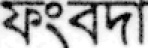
ফংবদা
